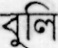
বুলি
